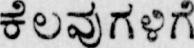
ಕೆಲವುಗಳಿಗೆ
